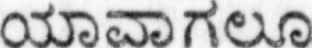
ಯಾವಾಗಲೂ
